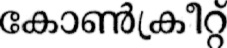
കോണ്‍ക്രീറ്റ്
